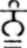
ਨੂੰ
